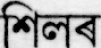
শিলৰ
